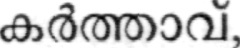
കര്‍ത്താവ്,
